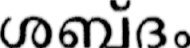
ശബ്ദം
